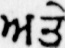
ਅਤੇ
